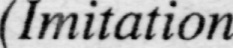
(Imitation
